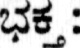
ಭಕ್ತ:
